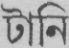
টানি
